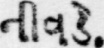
નીવડે.
